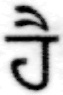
ਹੈ
